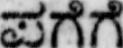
ಪಗೆಗೆ
